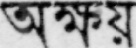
অক্ষয়
